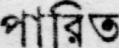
পারিত
